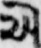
એ
